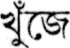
খুঁজে
